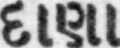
દાણા
